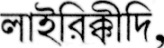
লাইরিক্কীদি,
